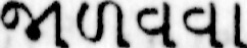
જાળવવા
